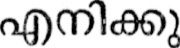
എനിക്കു
